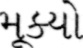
મૂક્યો
